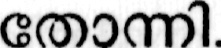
തോന്നി.
